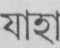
যাহা
